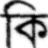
কি
